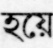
হয়ে
